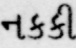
નકકી
